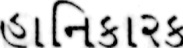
હાનિકારક
